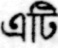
এটি
